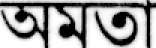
অমতা
